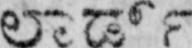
ಲಾರ್ಡ್
